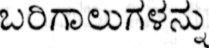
ಬರಿಗಾಲುಗಳನ್ನು
